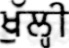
ਖੁੱਲ੍ਹੀ
